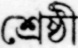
শ্রেষ্ঠী
